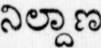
ನಿಲ್ದಾಣ
